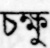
চক্ষু
